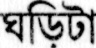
ঘড়িটা
